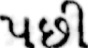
પછી
